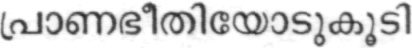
പ്രാണഭീതിയോടുകൂടി
